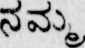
ನಮ್ಮ
